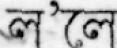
ল'লে
